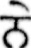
ਨੇ
